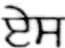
ਏਸ
